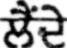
ਲੈਂਦੇ
